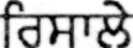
ਰਿਸਾਲੇ
